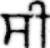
ਸੀ
